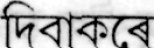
দিবাকৰে
